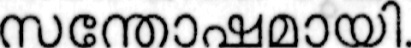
സന്തോഷമായി.
